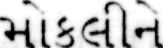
મોકલીને
